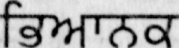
ਭਿਆਨਕ
